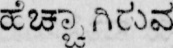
ಹೆಚ್ಚಾಗಿರುವ
